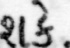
શકે.
